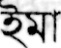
ইমা
